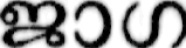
ജാഗ
